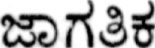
ಜಾಗತಿಕ
